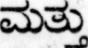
ಮತ್ತು
